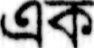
এক
